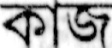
কাজ
